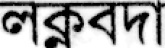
লক্নবদা
